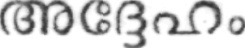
അദ്ദേഹം
